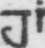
ਹਾਂ
